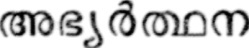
അഭ്യര്‍ത്ഥന
